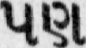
પણ
